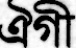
ঐগী
